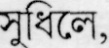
সুধিলে,
